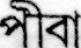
পীবা
